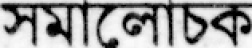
সমালোচক
